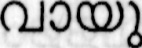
വായു
